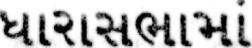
ધારાસભામાં
